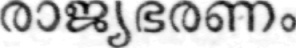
രാജ്യഭരണം
